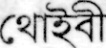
থোইবী
